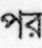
পর
